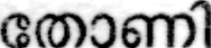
തോണി
